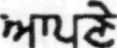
ਆਪਣੇ
